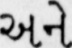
અને
